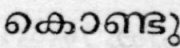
കൊണ്ടു
